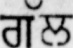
ਗੱਲ
